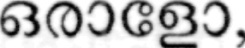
ഒരാളോ,
